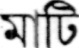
মাটি
